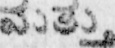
ಮತ್ತು
